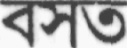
বসত
